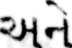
અને
